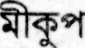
মীকুপ
